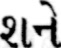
શને
